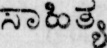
ಸಾಹಿತ್ಯ
